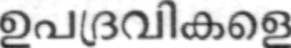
ഉപദ്രവികളെ
